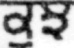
ਕੁਝ
